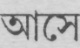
আসে
